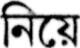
নিয়ে
